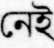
নেই
